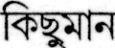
কিছুমান
